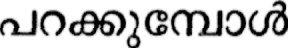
പറക്കുമ്പോള്‍
